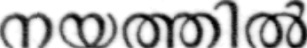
നയത്തില്‍
